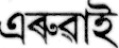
এৰুৱাই
